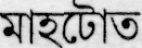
মাহটোত
